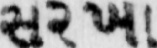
સરખા
